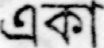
একা
